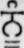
ਨੂੰ
